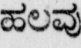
ಹಲವು
